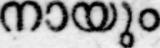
നായും
